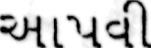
આપવી
